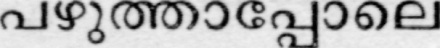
പഴുത്താപ്പോലെ
